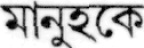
মানুহকে
